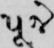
પૂજે
